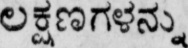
ಲಕ್ಷಣಗಳನ್ನು
